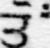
ਤੋਂ
